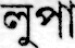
লুপা
